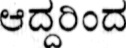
ಆದ್ದರಿಂದ
